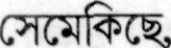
সেমেকিছে,
